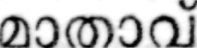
മാതാവ്
